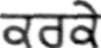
ਕਰਕੇ
